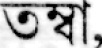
তম্বা,
